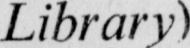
Library)
